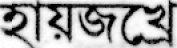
হায়জখ্রে
